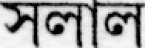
সলাল
